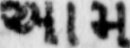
આમ
